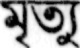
মৃত্যু
